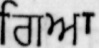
ਗਿਆ
